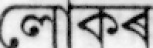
লোকৰ
